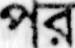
পর
